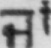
ਜਾਂ
